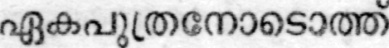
ഏകപുത്രനോടൊത്ത്
